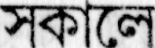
সকালে
